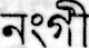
নংগী
